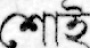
শোই
